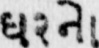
ઘરનો
